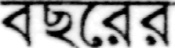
বছরের
